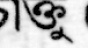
চাক্তু
